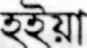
হইয়া
